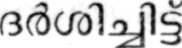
ദര്‍ശിച്ചിട്ട്
